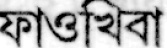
ফাওখিবা
